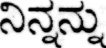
ನಿನ್ನನ್ನು
